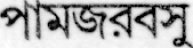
পামজরবসু
